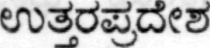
ಉತ್ತರಪ್ರದೇಶ
